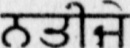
ਨਤੀਜੇ
